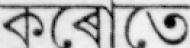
কৰোতে
